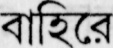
বাহিরে
